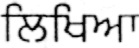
ਲਿਖਿਆ
